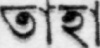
তাহা
